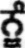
ਨੂੰ
